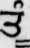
ਤੂੰ
